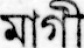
মাগী
